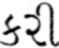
કરી
